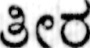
ತೀರ
